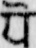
ਧੋ
